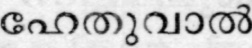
ഹേതുവാല്‍
